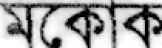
মকোক
